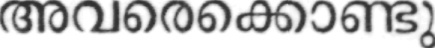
അവരെക്കൊണ്ടു
